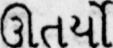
ઊતર્યો
